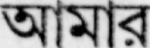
আমার
